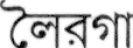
লৈরগা
